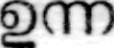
ഉന്ന
